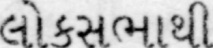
લોકસભાથી
